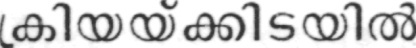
ക്രിയയ്ക്കിടയില്‍
